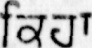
ਕਿਹਾ
